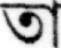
তা
